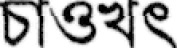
চাওখৎ
